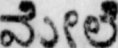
ಮೇಲೆ
